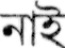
নাই
